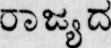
ರಾಜ್ಯದ
